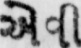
એવી
